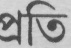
প্ৰতি
